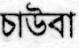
চাউবা
